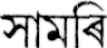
সামৰি
